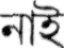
নাই
